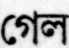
গেল
